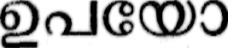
ഉപയോ
